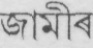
জামীৰ
